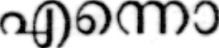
എന്നൊ
